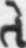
તે
